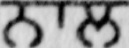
ਨਾਲ
